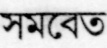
সমবেত
